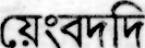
য়েংবদদি
